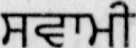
ਸਵਾਮੀ
